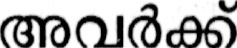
അവര്‍ക്ക്
